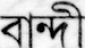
বান্দী
